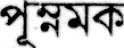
পূম্নমক
